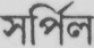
সর্পিল
